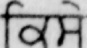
ਕਿਸੇ
